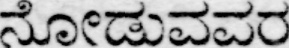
ನೋಡುವವರ
